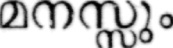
മനസ്സും
